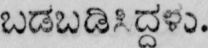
ಬಡಬಡಿಸಿದ್ದಳು.
